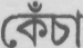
কেঁচা
